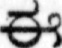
ಈ
